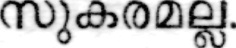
സുകരമല്ല.
